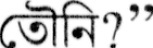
তৌনি?”
